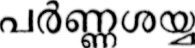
പര്‍ണ്ണശയ്യ
